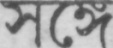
সঙ্গে
